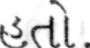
હતો.
